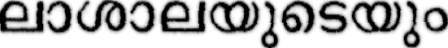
ലാശാലയുടെയും
